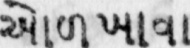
ઓળખાવા
